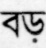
বড়
